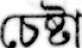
চেষ্টা
